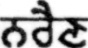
ਨਰੈਣ
